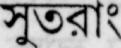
সুতরাং
